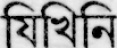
যিখিনি
